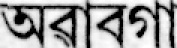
অৱাবগা
